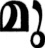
മു
